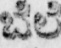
ಬೆಲೆ
